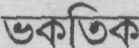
ভকতিক
